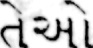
તેઓ
